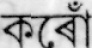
কৰোঁ
